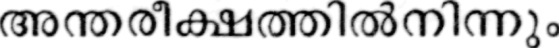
അന്തരീക്ഷത്തില്‍നിന്നും
